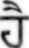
ਹੈ
